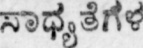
ಸಾಧ್ಯತೆಗಳ
